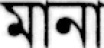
মানা
